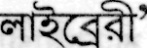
লাইব্রেরী’
